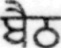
ਬੈਠ
